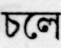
চলে
